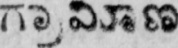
ಗ್ರಾಮೀಣ
